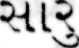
સારુ
